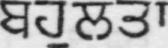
ਬਹੁਲਤਾ
